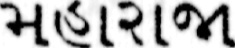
મહારાજા
